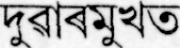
দুৱাৰমুখত
